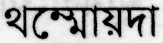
থম্মোয়দা
